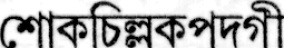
শোকচিল্লকপদগী
